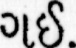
ગઈ.
